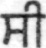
ਸੀ
